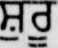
ਸ਼ੁਰੂ
